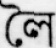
লৈ
